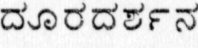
ದೂರದರ್ಶನ
